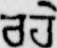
ਰਹੇ
